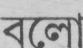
বলো
